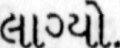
લાગ્યો.
